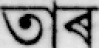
তাৰ
